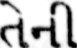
તેની
